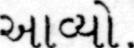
આવ્યો.
